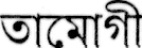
তামোগী
